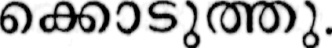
ക്കൊടുത്തു.
